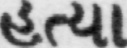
હત્યા
